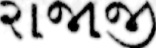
રાજાજી
